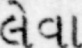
લેવા
